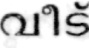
വീട്
